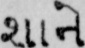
શાને
